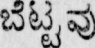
ಬೆಟ್ಟವು
